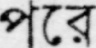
পরে
